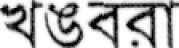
খঙবরা
